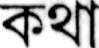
কথা
